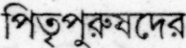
পিতৃপুরুষদের
